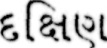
દક્ષિણ
